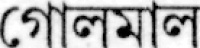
গোলমাল
